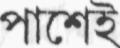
পাশেই
